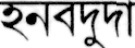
হনবদুদা
